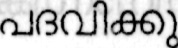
പദവിക്കു
